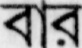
বার
